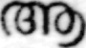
ആ
